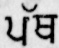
ਪੱਥ
